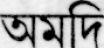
অমদি
